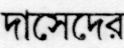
দাসেদের
